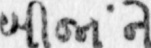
બીજાંને
